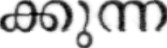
ക്കുന്ന
